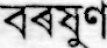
বৰষুণ
